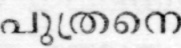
പുത്രനെ
